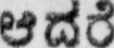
ಆದರೆ
